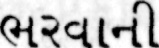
ભરવાની
